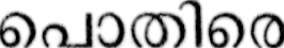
പൊതിരെ
